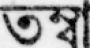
তম্বা
